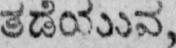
ತಡೆಯುವ,
